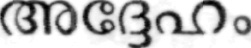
അദ്ദേഹം
